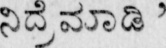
ನಿದ್ರೆಮಾಡಿ’
